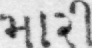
મારી
